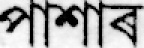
পাশাৰ
